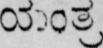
ಯಂತ್ರ
